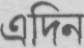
এদিন
